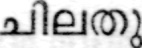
ചിലതു
